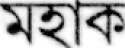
মহাক
